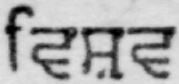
ਵਿਸ਼ਵ
